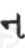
ન
